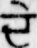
ਦੇ
